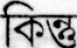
কিন্তু
